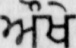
ਔਖੇ
